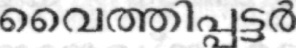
വൈത്തിപ്പട്ടര്‍
